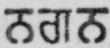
ਨਗਨ
